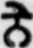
ਨੇ
